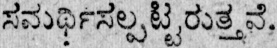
ಸಮರ್ಥಿಸಲ್ಪಟ್ಟಿರುತ್ತವೆ.
